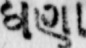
ધણા
